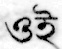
ওই
